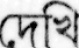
দেখি
